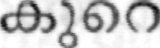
കുറെ
